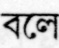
বলে
